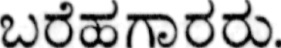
ಬರೆಹಗಾರರು.
